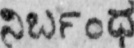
ನಿರ್ಬಂಧ
